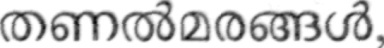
തണല്‍മരങ്ങള്‍,
